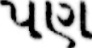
પણ
